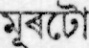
মূৰটো
